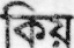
কিয়
